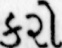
કરો
